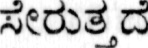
ಸೇರುತ್ತದೆ
